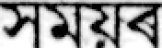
সময়ৰ
